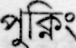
পুক্নিং
